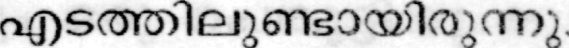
എടത്തിലുണ്ടായിരുന്നു.
